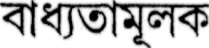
বাধ্যতামূলক
